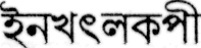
ইনখৎলকপী
